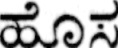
ಹೊಸ
